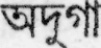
অদুগা
